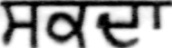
ਸਕਦਾ
